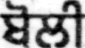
ਬੋਲੀ
